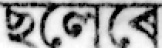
ছলেৰে
